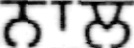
ਨਾਲ
